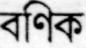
বণিক
